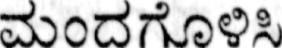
ಮಂದಗೊಳಿಸಿ
